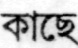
কাছে
